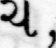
ચ,
